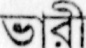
ভারী
